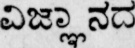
ವಿಜ್ಞಾನದ
